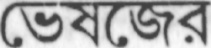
ভেষজের
